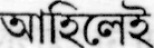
আহিলেই
